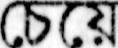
চেয়ে
